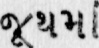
જૂથમાં
